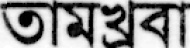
তামখ্রবা
